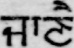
ਜਾਣੈ
